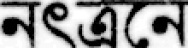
নৎত্রনে
